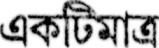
একটিমাত্র
